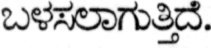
ಬಳಸಲಾಗುತ್ತಿದೆ.
